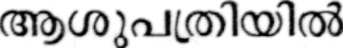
ആശുപത്രിയില്‍
